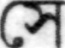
সে
